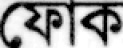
ফোক
